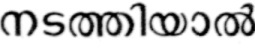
നടത്തിയാല്‍
